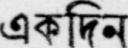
একদিন
